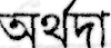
অর্থদা
